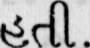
હતી.
